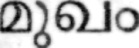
മുഖം
